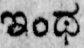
ಇಂಥ
